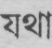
যথা
